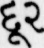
દૂર
